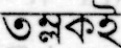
তম্লকই
